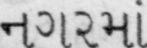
નગરમાં
